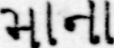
માના
